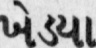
ખેડ્યા
